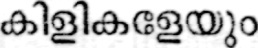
കിളികളേയും
